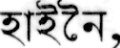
হাইনৈ,
